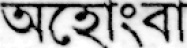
অহোংবা
